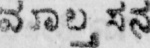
ಮಾಲ್ತಸನ
